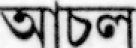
আচল
